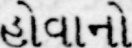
હોવાનો
